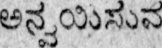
ಅನ್ವಯಿಸುವ
